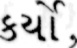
કર્યો,
